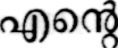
എന്റെ
